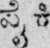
ಪೈಕಿ
